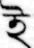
ই
